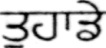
ਤੁਹਾਡੇ
